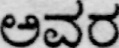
ಅವರ
